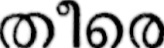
തീരെ
